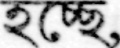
হচ্ছে,
